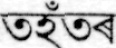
তহঁতৰ
